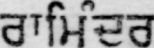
ਰਾਮਿੰਦਰ
